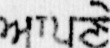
ਆਪਣੇ
